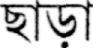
ছাড়া
